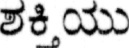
ಶಕ್ತಿಯು
